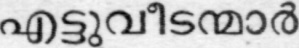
എട്ടുവീടന്മാര്‍
